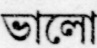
ভালো
